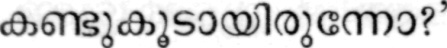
കണ്ടുകൂടായിരുന്നോ?'
